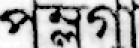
পম্লগা
